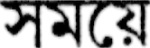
সময়ে
